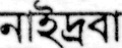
নাইদ্রবা
